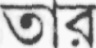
তার
